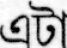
এটা
